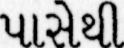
પાસેથી
